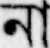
না
